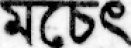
মচেৎ
